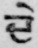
ਦੇ
